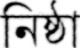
নিষ্ঠা
